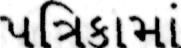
પત્રિકામાં
